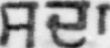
ਸਦਾ
